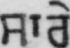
ਸਾਰੇ
